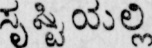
ಸೃಷ್ಟಿಯಲ್ಲಿ
